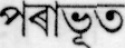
পৰাভূত
